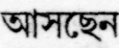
আসছেন
